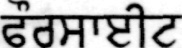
ਫੌਰਸਾਈਟ
